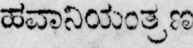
ಹವಾನಿಯಂತ್ರಣ
